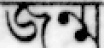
জন্ম
